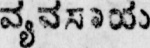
ವ್ಯವಸಾಯ
